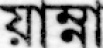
য়াম্না
